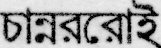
চান্নররোই
